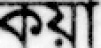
কয়া
